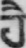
ਹੈ
